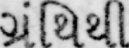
ગ્રંથિથી
